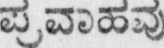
ಪ್ರವಾಹವು
